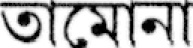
তামোনা
